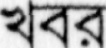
খবর
